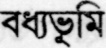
বধ্যভূমি
